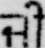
ਜੀ
